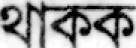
থাকক
